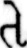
તે
